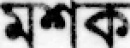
মশক
